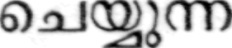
ചെയ്യുന്ന
